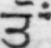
ਤੋਂ
